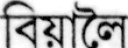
বিয়ালৈ
